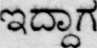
ಇದ್ದಾಗ
